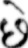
છે
